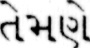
તેમણે
